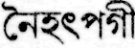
নৈহৎপগী
